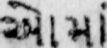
ઓમાં
